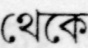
থেকে
